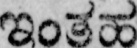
ಇಂತಹ
